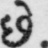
છે.
